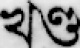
খণ্ড
